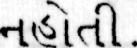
નહોતી.
